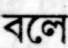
বলে
